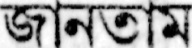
জানতাম
